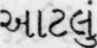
આટલું
